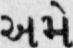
અમે
